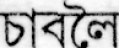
চাবলৈ
